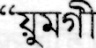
“য়ুমগী
